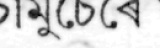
চামুচেৰে
